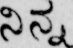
ನಿನ್ನ
